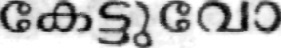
കേട്ടുവോ
